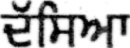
ਦੱਸਿਆ
